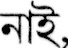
নাই,
